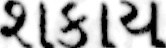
શકાય
